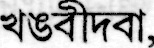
খঙবীদবা,
